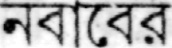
নবাবের
